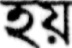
হয়
